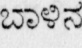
ಬಾಳಿನ
